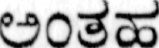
ಅಂತಹ
